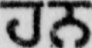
ਹਨ
